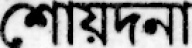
শোয়দনা
